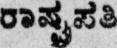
ರಾಷ್ಟ್ರಪತಿ
